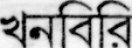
খনবিরি
